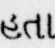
હતા
